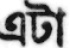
এটা
